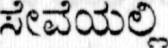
ಸೇವೆಯಲ್ಲಿ
